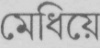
মেধিয়ে
